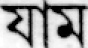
যাম
